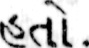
હતો.
